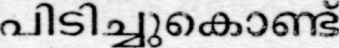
പിടിച്ചുകൊണ്ട്
